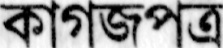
কাগজপত্র
